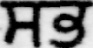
ਸਭ
